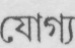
যোগ্য
